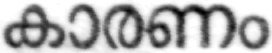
കാരണം
